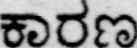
ಕಾರಣ
